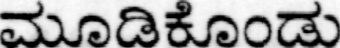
ಮೂಡಿಕೊಂಡು
